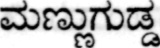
ಮಣ್ಣುಗುಡ್ಡ
